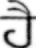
ਹੈ
